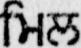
ਮਿਲ
